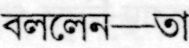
বললেন–তা
